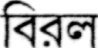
বিরল
